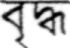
বৃদ্ধ
